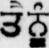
ਤੈਨੂੰ
